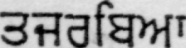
ਤਜਰਬਿਆ
